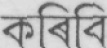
কৰিবি
